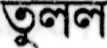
তুলল
